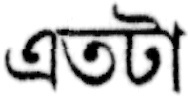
এতটা
